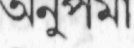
অনুপমা
